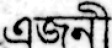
এজনী
